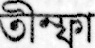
তীম্ফা
